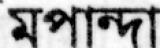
মপান্দা
